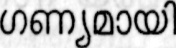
ഗണ്യമായി
